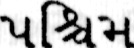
પશ્ચિમ
